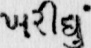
ખરીધું
